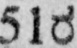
51ರ
